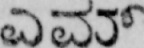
ಎಮ್
